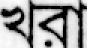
খরা
